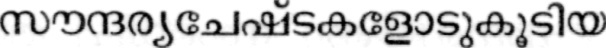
സന്ദര്യചേഷ്ടകളോടുകൂടിയ
